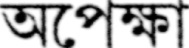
অপেক্ষা
